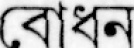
বোধন
